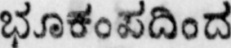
ಭೂಕಂಪದಿಂದ
